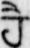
ਹੈ
